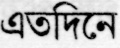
এতদিনে
